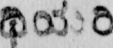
ಥಿಯರಿ
